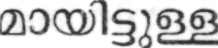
മായിട്ടുള്ള
